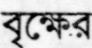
বৃক্ষের
